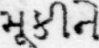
મૂકીને
